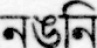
নঙনি
